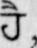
ਹੈ,
